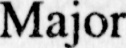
Major
